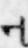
ન
